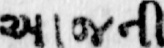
આજની
